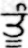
ਤੂੰ
